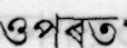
ওপৰত
